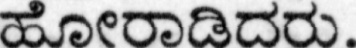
ಹೋರಾಡಿದರು.
